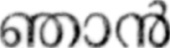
ഞാന്‍
